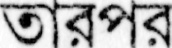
তারপর
